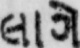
લાગે
